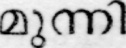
മുന്നി
